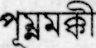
পূম্নমক্কী
